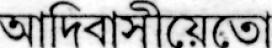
আদিবাসীয়েতো
